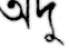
অদু
